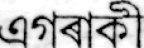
এগৰাকী
